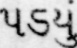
પડ્યું
